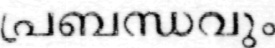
പ്രബന്ധവും
